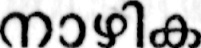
നാഴിക
